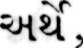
અર્થે,
